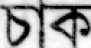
চাক
